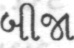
બીજા
